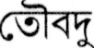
তৌবদু
